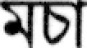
মচা
